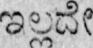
ಇಲ್ಲದೇ
